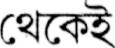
থেকেই
